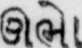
ઊભો
